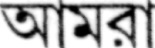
আমরা
